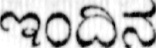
ಇಂದಿನ
